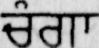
ਚੰਗਾ
